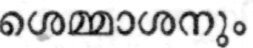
ശെമ്മാശനും
